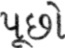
પૂછો
